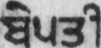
ਬੇਪਤੀ
